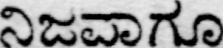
ನಿಜವಾಗೂ
